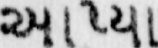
આપ્યા
